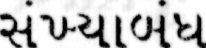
સંખ્યાબંધ
